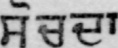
ਸੋਚਦਾ
